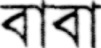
বাবা
